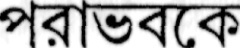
পরাভবকে
